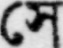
সে
